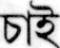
চাই
